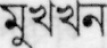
মুখখন
